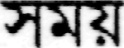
সময়
